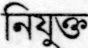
নিযুক্ত
